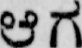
ಆಗ
